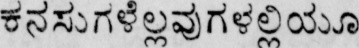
ಕನಸುಗಳೆಲ್ಲವುಗಳಲ್ಲಿಯೂ
